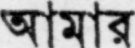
আমার
